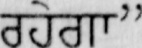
ਰਹੇਗਾ''
